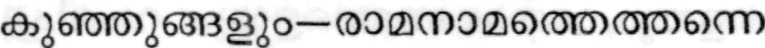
കുഞ്ഞുങ്ങളും-രാമനാമത്തെത്തന്നെ
